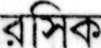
রসিক
